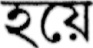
হয়ে
